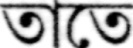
তাতে
